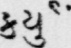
કર્યું
